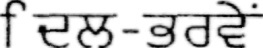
ਦਿਲ-ਭਰਵੇਂ
